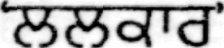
''ਲਲਕਾਰ''
